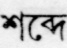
শব্দে
